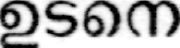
ഉടനെ
